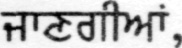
ਜਾਣਗੀਆਂ,
